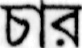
চার
